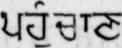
ਪਹੁੰਚਾਣ
